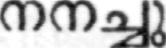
നനച്ചു
